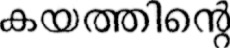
കയത്തിന്റെ
